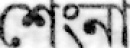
শেংনা
